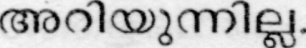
അറിയുന്നില്ല.
